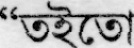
"তইতো
